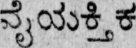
ವೈಯಕ್ತಿಕ
